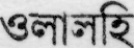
ওলালহি
